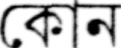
কোন
